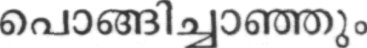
പൊങ്ങിച്ചാഞ്ഞും
